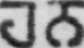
ਹਨ
